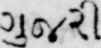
ગુજરી
